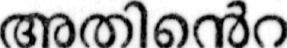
അതിന്റെ
